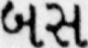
બસ
